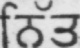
ਨਿੱਤ
